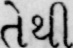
તેથી
